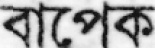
বাপেক
